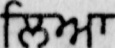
ਲਿਆ
